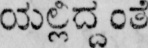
ಯಲ್ಲಿದ್ದಂತೆ
